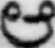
ಆ
